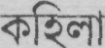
কহিলা
